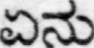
ಏನು
